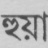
হুয়া
